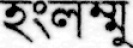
হংলম্মু
